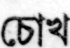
চোখ
